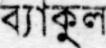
ব্যাকুল
